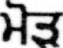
ਮੋੜ
